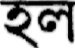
হল
